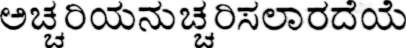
ಅಚ್ಚರಿಯನುಚ್ಚರಿಸಲಾರದೆಯೆ
